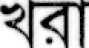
খরা
